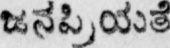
ಜನಪ್ರಿಯತೆ
